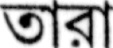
তারা
